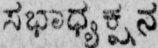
ಸಭಾಧ್ಯಕ್ಷನ
